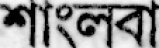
শাংলবা
